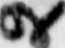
જ
